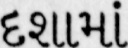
દશામાં
